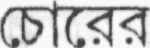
চোরের
